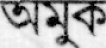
অমুক
